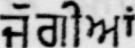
ਜੋਗੀਆਂ
